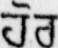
ਹੋਰ
